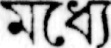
মধ্যে
